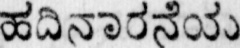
ಹದಿನಾರನೆಯ
